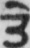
ਤੇ
